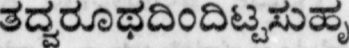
ತದ್ವರೂಥದಿಂದಿಟ್ಟಸುಹ
